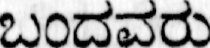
ಬಂದವರು
